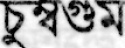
চুম্বগুম
